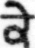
ਕੇ
